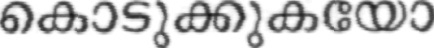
കൊടുക്കുകയോ
